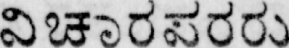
ವಿಚಾರಪರರು
